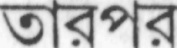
তারপর
